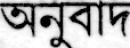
অনুবাদ
